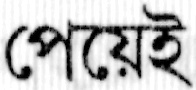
পেয়েই
